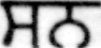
ਸਨ
